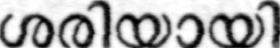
ശരിയായി
